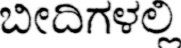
ಬೀದಿಗಳಲ್ಲಿ
